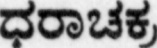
ಧರಾಚಕ್ರ
